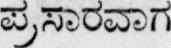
ಪ್ರಸಾರವಾಗ
